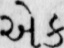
એક
